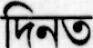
দিনত
